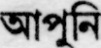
আপুনি
